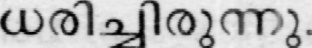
ധരിച്ചിരുന്നു.
